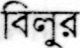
বিলুর
